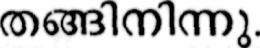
തങ്ങിനിന്നു.
